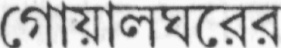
গোয়ালঘরের
